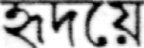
হৃদয়ে
